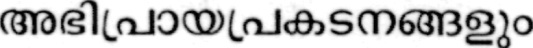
അഭിപ്രായപ്രകടനങ്ങളും
